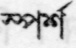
স্পর্শ
